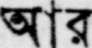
আর
